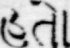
હતો
